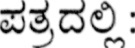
ಪತ್ರದಲ್ಲಿ:
